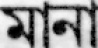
মানা
